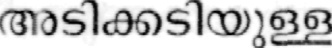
അടിക്കടിയുള്ള
